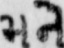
મને
